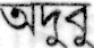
অদুবু
